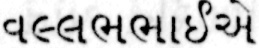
વલ્લભભાઈએ
